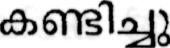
കണ്ടിച്ചു
